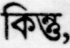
কিন্তু,
